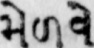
મેળવે
